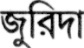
জুরিদা
